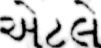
એટલે
